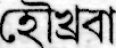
হৌখ্রবা
